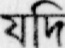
যদি
